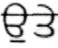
ਉਤੇ
